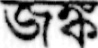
জঙ্ক
